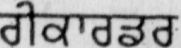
ਰੀਕਾਰਡਰ
